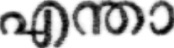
എന്താ
